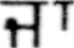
ਜਾ
